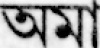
অমা
